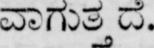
ವಾಗುತ್ತದೆ.
